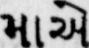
માએ
